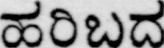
ಹರಿಬದ
